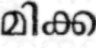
മിക്ക
